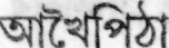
আখৈপিঠা
